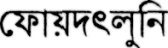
ফোয়দৎলুনি
